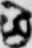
છે
